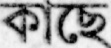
কাছে
